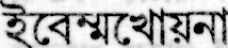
ইবেম্মখোয়না
